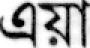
এয়া
